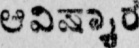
ಆವಿಷ್ಕಾರ
